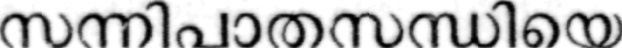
സന്നിപാതസന്ധിയെ
